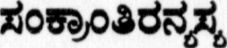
ಸಂಕ್ರಾಂತಿರನ್ಯಸ್ಯ
